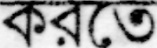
করতে
